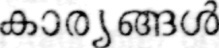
കാര്യങ്ങള്‍
